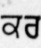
ਕਰ
